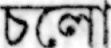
চলো
